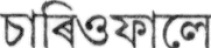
চাৰিওফালে
